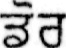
ਡੋਰ
